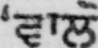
'ਵਾਲੋ
